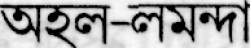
অহল-লমন্দা
